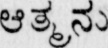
ಆತ್ಮನು
